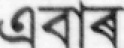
এবাৰ
